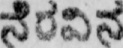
ನೆರವಿನ
